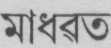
মাধৱত
